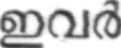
ഇവര്‍
